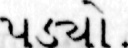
પડ્યો.
